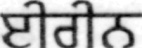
ਈਰੀਨ
